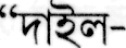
"দাইল-
